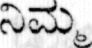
ನಿಮ್ಮ
